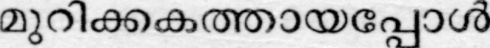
മുറിക്കകത്തായപ്പോള്‍
